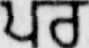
ਪਰ
